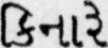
કિનારે
